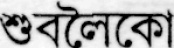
শুবলৈকো
